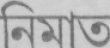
নিমাত
